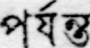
পর্যন্ত
